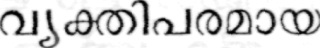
വ്യക്തിപരമായ
